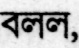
বলল,
